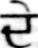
ਦੇ
